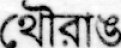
থৌরাঙ
